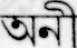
অনী
